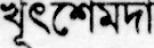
খূৎশেমদা
